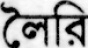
লৈরি
